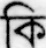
কি
